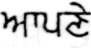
ਆਪਣੇ
